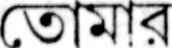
তোমার
